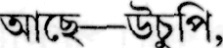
আছে-উচুপি,
